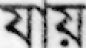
যায়
